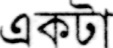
একটা
